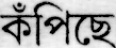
কঁপিছে
